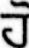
ਹੋ
